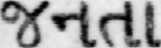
જનતા
